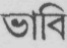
ভাবি
